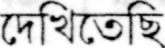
দেখিতেছি
